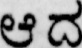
ಆದ
